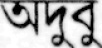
অদুবু
